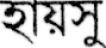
হায়সু
